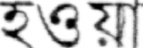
হওয়া
